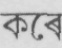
কৰে
